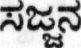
ಸಜ್ಜನ
